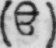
(ੳ)
